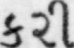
કરી
